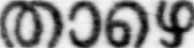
താഴെ
